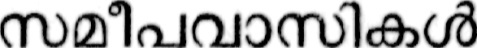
സമീപവാസികള്‍
